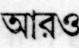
আরও
